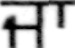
ਜਾ
